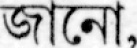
জানো,
